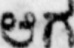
ಆಗ
